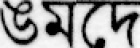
ঙমদে
